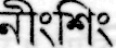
নীংশিং
